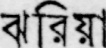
ঝরিয়া
